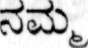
ನಮ್ಮ
